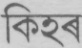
কিহৰ
